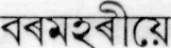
বৰমহৰীয়ে
